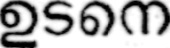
ഉടനെ
